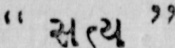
"સત્ય"
